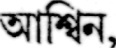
আশ্বিন,
